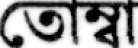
তোম্বা
